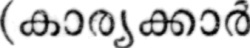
(കാര്യക്കാര്‍
